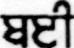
ਬਈ
